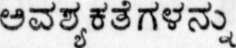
ಅವಶ್ಯಕತೆಗಳನ್ನು
